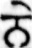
ਨੇ
